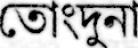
তোংদুনা
